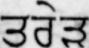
ਤਰੇੜ
